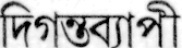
দিগন্তব্যাপী
